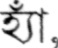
হ্যাঁ,
